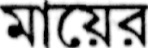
মায়ের
